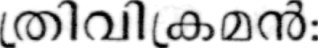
ത്രിവിക്രമന്‍:
